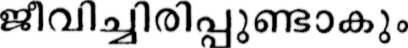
ജീവിച്ചിരിപ്പുണ്ടാകും
